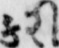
કરી
